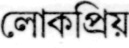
লোকপ্রিয়
